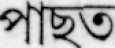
পাছত
